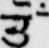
ਤੋਂ
